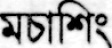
মচাশিং
